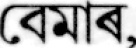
বেমাৰ,
